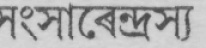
সংসাৰেন্দ্ৰস্য
